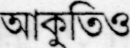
আকুতিও
